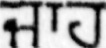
ਜਾਹ
